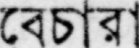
বেচারা
